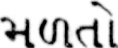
મળતો
